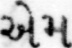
એમ
